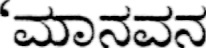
'ಮಾನವನ
